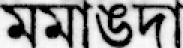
মমাঙদা
